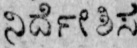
ನಿರ್ದೇಶಿಸ
